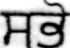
ਸਭੋ
